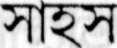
সাহস
